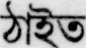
ঠাইত
